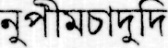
নুপীমচাদুদি
